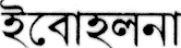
ইবোহলনা
